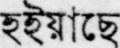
হইয়াছে
